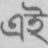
এই
